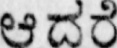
ಆದರೆ
